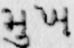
મુખ
